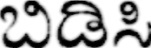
ಬಿಡಿಸಿ
